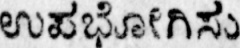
ಉಪಭೋಗಿಸು
